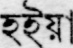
হইয়া
